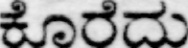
ಕೊರೆದು
